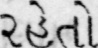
રહેતો
